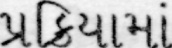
પ્રક્રિયામાં
